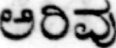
ಅರಿವು
